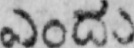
ಎಂದು
